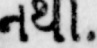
નથી.
